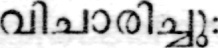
വിചാരിച്ചു:
